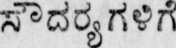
ಸೌದರ್‍ಯಗಳಿಗೆ
